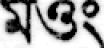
মওং
